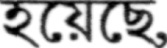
হয়েছে,
